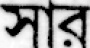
সার
